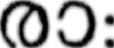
രാ:
